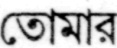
তোমার
